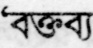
‘বক্তব্য
